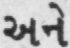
મૂર્ખ
